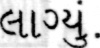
લાગ્યું.
